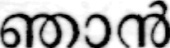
ഞാന്‍
